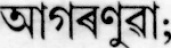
আগৰণুৱা;
